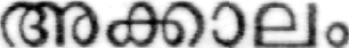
അക്കാലം
